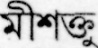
মীশক্তু
